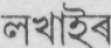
লখাইৰ
